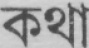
কথা
